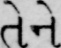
તેને
